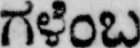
ಗಳೆಂಬ
